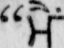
''ਮੈਂ
